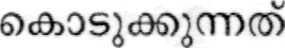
കൊടുക്കുന്നത്
